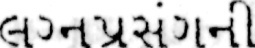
લગ્નપ્રસંગની
